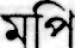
মপি
